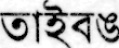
তাইবঙ
